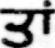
ਤਾਂ
